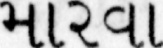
મારવા
